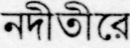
নদীতীরে
